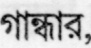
গান্ধার,
